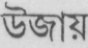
উজায়
